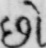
છો
